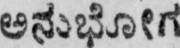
ಅನುಭೋಗ
